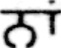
ਨਾਂ
